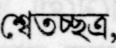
শ্বেতচ্ছত্র,
